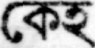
কেহ
